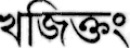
খজিক্তং
